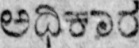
ಅಧಿಕಾರ
